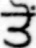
ਤੋਂ
